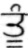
ਤੂੰ
